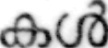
കള്‍
